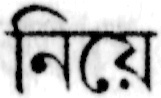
নিয়ে
